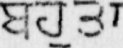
ਬਹੁਤਾ
